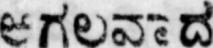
ಅಗಲವಾದ
